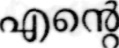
എന്റെ
